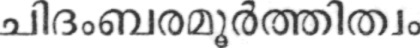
ചിദംബരമൂര്‍ത്തിത്വം
